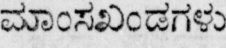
ಮಾಂಸಖಂಡಗಳು
